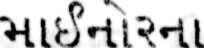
માઈનોરના
